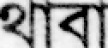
থাবা
